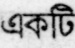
একটি
